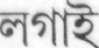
লগাই
